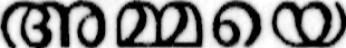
അമ്മയെ
